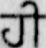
ਹੀ
